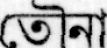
তৌনা
